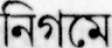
নিগমে
